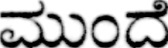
ಮುಂದೆ
